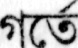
গর্তে
